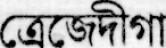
ত্রেজেদীগা
